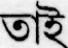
তাই
